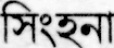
সিংহনা
